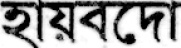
হায়বদো
